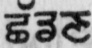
ਛੱਡਣ
